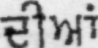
ਦੀਆਂ
